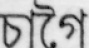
চাগৈ
